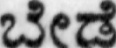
ಬೇಡೆ
